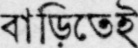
বাড়িতেই
